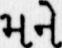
મને
